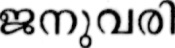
ജനുവരി
